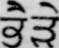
ਭੈੜੇ
